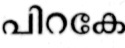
പിറകേ
